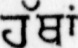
ਹੱਥਾਂ
